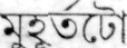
মুহূর্তটো
